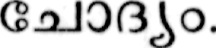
ചോദ്യം.
